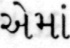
એમાં
